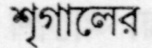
শৃগালের
